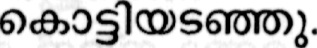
കൊട്ടിയടഞ്ഞു.
